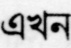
এখন
